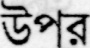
উপর
